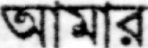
আমার
